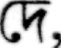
দে,
